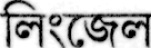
লিংজেল
